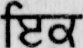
ਇਕ
